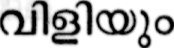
വിളിയും
